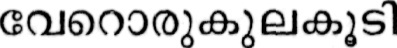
വേറൊരുകുലകൂടി
